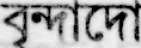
বৃন্দাদো
